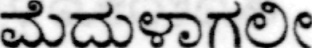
ಮೆದುಳಾಗಲೀ
